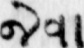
જેવા
